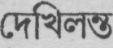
দেখিলন্ত
